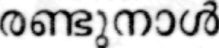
രണ്ടുനാള്‍
